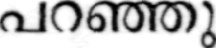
പറഞ്ഞു
